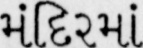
મંદિરમાં
